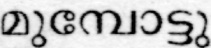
മുമ്പോട്ടു
